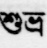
শুভ্র
